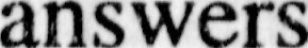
answers
